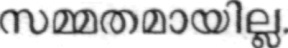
സമ്മതമായില്ല.
